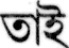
তাই
